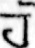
ਹੋ
